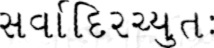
સર્વાદિરચ્યુચઃ
